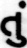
તું
